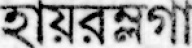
হায়রম্লগা
